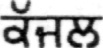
ਕੱਜਲ
